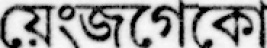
য়েংজগেকো
